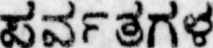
ಪರ್ವತಗಳ
